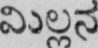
ಮಿಲ್ಲನ
